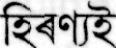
হিৰণ্যই
